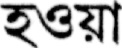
হওয়া
